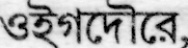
ওইগদৌরে,
